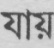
যায়
